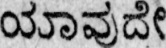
ಯಾವುದೇ
